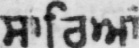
ਸਾਰਿਆਂ
